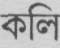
কলি
